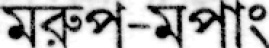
মরুপ-মপাং
